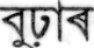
বুঢ়াৰ
